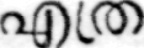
എത്ര
